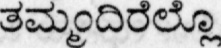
ತಮ್ಮಂದಿರೆಲ್ಲೊ
